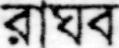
রাঘব
